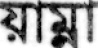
য়াম্না
